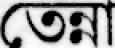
তেন্না
